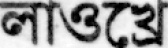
লাওখ্রে
